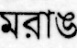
মরাঙ
